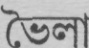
ভৈলা
